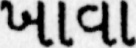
ખાવા
